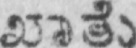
ಖಾತು
